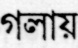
গলায়
